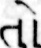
તો
